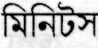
মিনিটস
